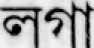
লগা
